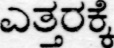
ಎತ್ತರಕ್ಕೆ
